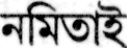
নমিতাই
